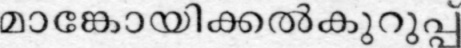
മാങ്കോയിക്കല്‍കുറുപ്പ്
